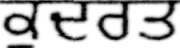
ਕੁਦਰਤ
